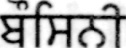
ਬੌਸਿਨੀ
